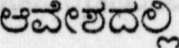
ಆವೇಶದಲ್ಲಿ
